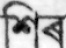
শিৰ
